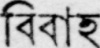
বিবাহ
